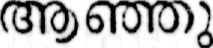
ആഞ്ഞു
